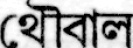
থৌবাল
